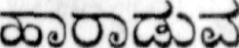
ಹಾರಾಡುವ
